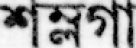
শম্লগা
